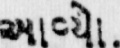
આવ્યો.
